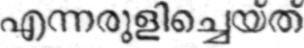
എന്നരുളിച്ചെയ്ത്
